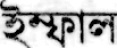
ইম্ফাল
